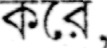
করে,
